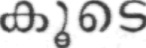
കൂടെ
